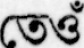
তেওঁ
